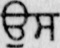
ਉਸ
